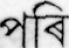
পৰি
